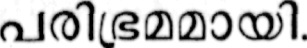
പരിഭ്രമമായി.
